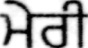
ਮੇਰੀ
